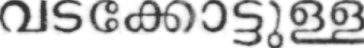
വടക്കോട്ടുള്ള
